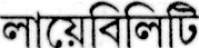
লায়েবিলিটি
